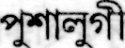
পুশালুগী
